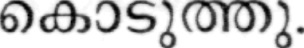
കൊടുത്തു.
